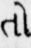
તો
